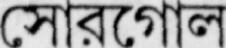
সোরগোল
